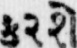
કરશે
